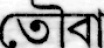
তৌবা
